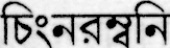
চিংনরম্বনি
